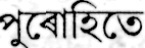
পুৰোহিতে
